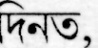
দিনত,
